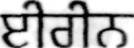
ਈਰੀਨ
